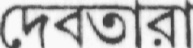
দেবতারা
